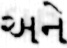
અને
